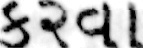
કરવા
